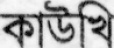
কাউখি
